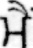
ਮੈਂ
